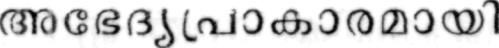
അഭേദ്യപ്രാകാരമായി
